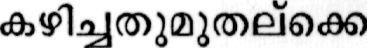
കഴിച്ചതുമുതല്ക്കെ
